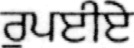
ਰੁਪਈਏ
